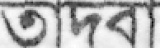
তাদবা
